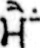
ਮੈਂ
